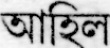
আহিল
